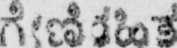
ಗೇಣಿರಹಿತ
